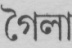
গৈলা
